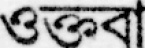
ওক্তবা
